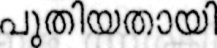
പുതിയതായി
